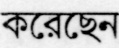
করেছেন
